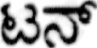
ಟನ್
